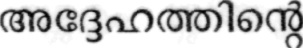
അദ്ദേഹത്തിന്റെ
